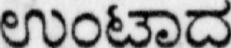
ಉಂಟಾದ
